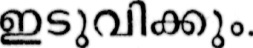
ഇടുവിക്കും.
